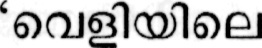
'വെളിയിലെ
